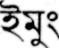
ইমুং
